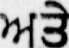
ਅਤੇ
